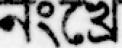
নংখ্রে
